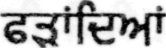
ਫੜਾਂਦਿਆਂ
